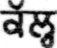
ਕੱਲ੍ਹ
